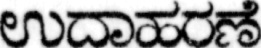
ಉದಾಹರಣೆ
